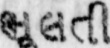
ભૂલતી
